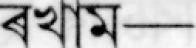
ৰখাম-
